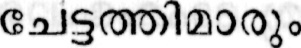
ചേട്ടത്തിമാരും
